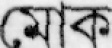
মোক
